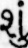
શું
